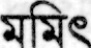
মমিৎ
